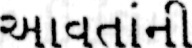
આવતાંની
